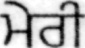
ਮੇਰੀ
